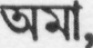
অমা,
